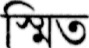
স্মিত
